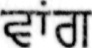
ਵਾਂਗ
